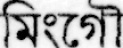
মিংগৌ
